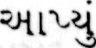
આપ્યું
